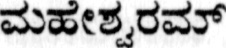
ಮಹೇಶ್ವರಮ್
